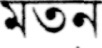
মতন
